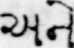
અને
